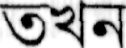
তখন
